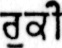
ਰੁਕੀ
